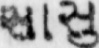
સાસુ
